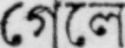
গেলে
